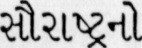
સૌરાષ્ટ્રનો
